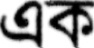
এক
